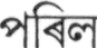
পৰিল
